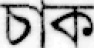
চাক
